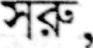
সরু,
